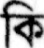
কি
